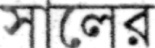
সালের
